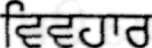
ਵਿਵਹਾਰ
